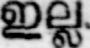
ഇല്ല.
